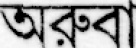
অরুবা
